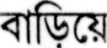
বাড়িয়ে
